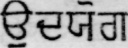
ਉਦਯੋਗ
